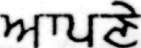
ਆਪਣੇ
